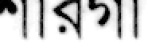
শারগা
